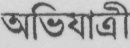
অভিযাত্ৰী
